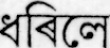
ধৰিলে
